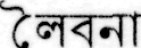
লৈবনা
